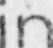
in
